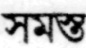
সমস্ত
